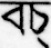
বচ্
